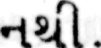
નથી.
